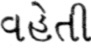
વહેતી
